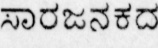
ಸಾರಜನಕದ
